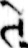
તે
